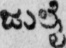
ಜುಲೈ
